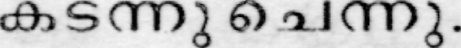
കടന്നുചെന്നു.
